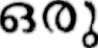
ഒരു
